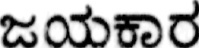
ಜಯಕಾರ
